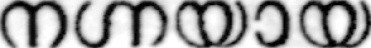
നഗ്നയായ
